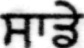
ਸਾਡੇ
